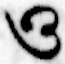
ও
